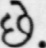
છે.
